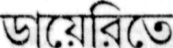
ডায়েরিতে
